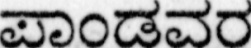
ಪಾಂಡವರ
